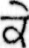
ਕੇ
